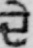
ਦੇ
